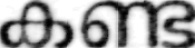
കണ്ട
